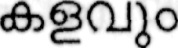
കളവും
